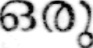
ഒരു
